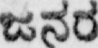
ಜನರ
